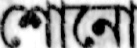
শোনো
